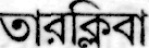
তারক্লিবা
